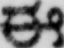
ಈ
